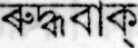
ৰুদ্ধবাক্
